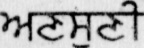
ਅਣਸੁਣੀ
